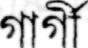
গার্গী
